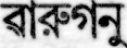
ৱারুগনু
